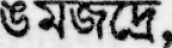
ঙমজদ্রে,
